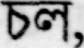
চল,
